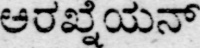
ಅರಖ್ನೆಯನ್
